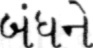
બંધને
